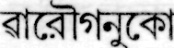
ৱারৌগনুকো
